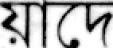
য়াদে
